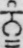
ਨੂੰ
